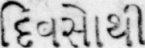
દિવસોથી
